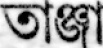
তাঞ্জা
